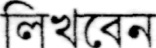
লিখবেন
